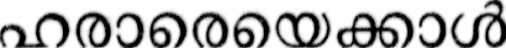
ഹരാരെയെക്കാള്‍
